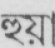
হুয়া
